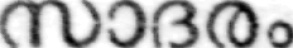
സാദരം
